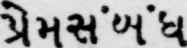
પ્રેમસંબંધ
